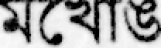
মখোঙ
